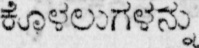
ಕೊಳಲುಗಳನ್ನು
